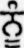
ਨੂੰ
